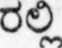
ರಲ್ಲಿ
